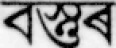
বস্তুৰ
